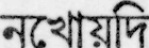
নখোয়দি
